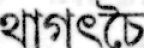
থাগৎচৈ
